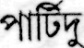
পার্টিদু
